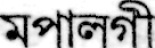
মপালগী
